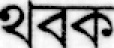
থবক
